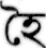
হৈ
